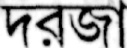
দরজা
